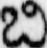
ಬಿ
